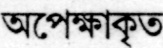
অপেক্ষাকৃত
